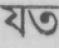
যত
